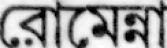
রোমেন্না
